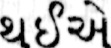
થઈએ
